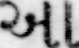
આ
